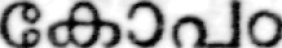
കോപം
